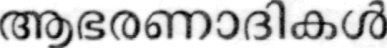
ആഭരണാദികള്‍
